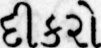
દીકરો
